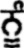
ਨੂੰ
